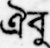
ঐবু
